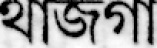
থাজগা
